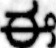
ಈ
